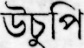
উচুপি
